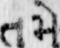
તમે
